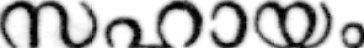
സഹായം
